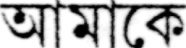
আমাকে
